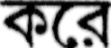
করে
